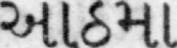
આઠમા
